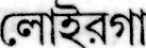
লোইরগা
